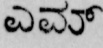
ಎಮ್
